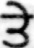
ਤੇ
